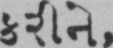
કરીને,
